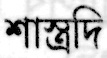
শাস্ত্রদি
